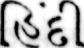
હિંદી
